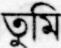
তুমি
